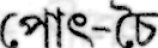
পোৎ-চৈ
